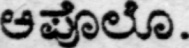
ಅಪೊಲೊ.
